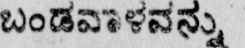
ಬಂಡವಾಳವನ್ನು
